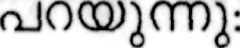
പറയുന്നു:
